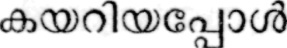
കയറിയപ്പോള്‍
